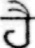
ਹੈ
